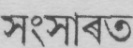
সংসাৰত
